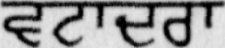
ਵਟਾਦਰਾ
